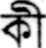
কী
